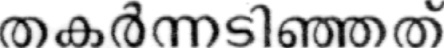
തകര്‍ന്നടിഞ്ഞത്
